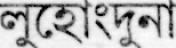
লুহোংদুনা
